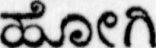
ಹೋಗಿ
